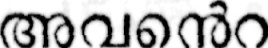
അവന്റെ
